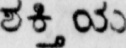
ಶಕ್ತಿಯ
